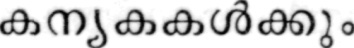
കന്യകകള്‍ക്കും
